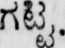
ಗಟ್ಟಿ.
